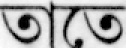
তাতে
